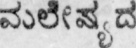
ಮಲೇಷ್ಯದ
